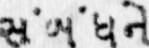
સંબંધને
